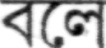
বলে
